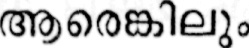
ആരെങ്കിലും
